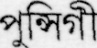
পুন্সিগী
